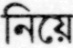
নিয়ে
